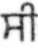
ਸੀ
